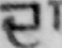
ਦਾ
